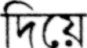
দিয়ে
